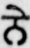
ਨੇ
